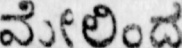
ಮೇಲಿಂದ
